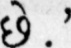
છે.'
